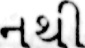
નથી
